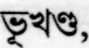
ভূখণ্ড,
